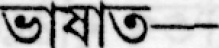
ভাষাত-
